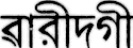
ৱারীদগী
